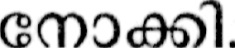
നോക്കി.
